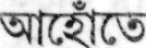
আহোঁতে
